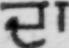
ਦਾ
